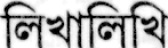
লিখালিখি
